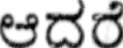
ಆದರೆ
